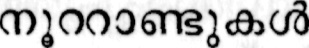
നൂററാണ്ടുകള്‍
